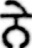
ਨੇ
